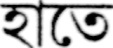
হাতে
